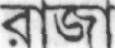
রাজা
